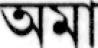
অমা
